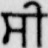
ਸੀ
